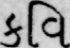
કવિ
